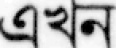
এখন
